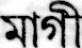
মাগী
